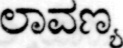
ಲಾವಣ್ಯ
